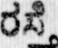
ರಸ್ತೆ
